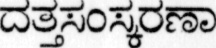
ದತ್ತಸಂಸ್ಕರಣಾ
